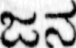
ಜನ
